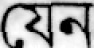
যেন
